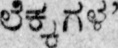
ಲೆಕ್ಕಗಳ’
